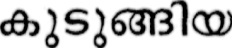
കുടുങ്ങിയ
